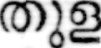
തുള
